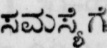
ಸಮಸ್ಯೆಗೆ
